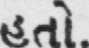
હતો.
